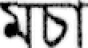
মচা
